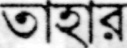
তাহার
